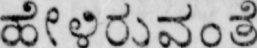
ಹೇಳಿರುವಂತೆ
